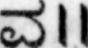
ವ||
